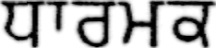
ਧਾਰਮਕ
